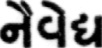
નૈવેધ
